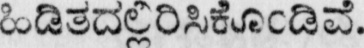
ಹಿಡಿತದಲ್ಲಿರಿಸಿಕೊಂಡಿವೆ.
